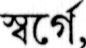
স্বর্গে,
